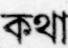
কথা
